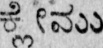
ಕ್ಲೇಮು
